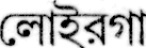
লোইরগা
